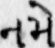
નમે
